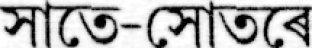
সাতে-সোতৰে
